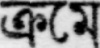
ক্রমে
